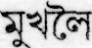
মুখলৈ
